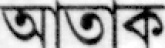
আতাক
